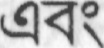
এবং
